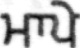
ਮਾਪੇ
